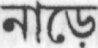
নাড়ে
